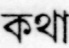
কথা
